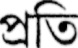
প্রতি
